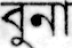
বুনা
